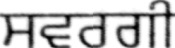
ਸਵਰਗੀ
